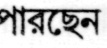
পারছেন
